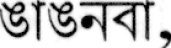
ঙাঙনবা,
